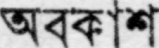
অবকাশ
